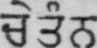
ਚੇਤੰਨ
